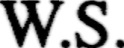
W.S.
